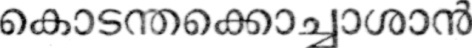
കൊടന്തക്കൊച്ചാശാന്‍
